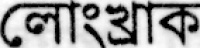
লোংখ্রাক
